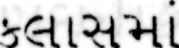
કલાસમાં
